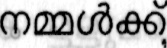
നമ്മള്‍ക്ക്
